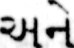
અને
